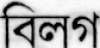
বিলগ
